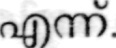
എന്ന്.
